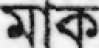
মাক
